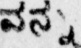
ವನ್ನು
